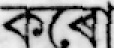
কৰো
